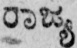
ರಾಜ್ಯ
